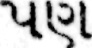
પણ
